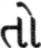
તો
